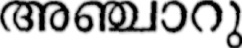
അഞ്ചാറു
